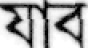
যাব
